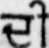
ਦੀ
